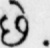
છે.
